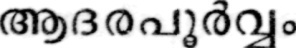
ആദരപൂര്‍വ്വം
